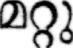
മറ്റു
